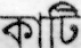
কাটি
